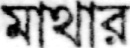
মাথার
